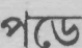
পড়ে
